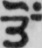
ਤੋਂ
